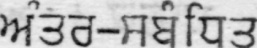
ਅੰਤਰ-ਸਬੰਧਿਤ
